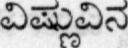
ವಿಷ್ಣುವಿನ
